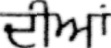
ਦੀਆਂ
